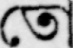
তো
